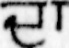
ਦਾ
